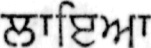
ਲਾਇਆ
